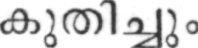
കുതിച്ചും
